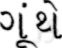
ગૂંથે
